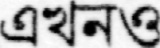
এখনও
